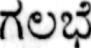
ಗಲಭೆ
